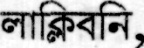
লাক্লিবনি,
